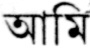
আমি
